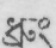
ধ্ৰুং
